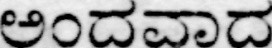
ಅಂದವಾದ
